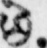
છે.
